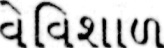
વેવિશાળ
